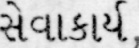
સેવાકાર્ય,
